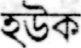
হউক
